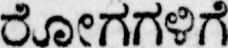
ರೋಗಗಳಿಗೆ
